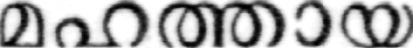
മഹത്തായ
